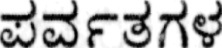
ಪರ್ವತಗಳ
